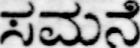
ಸಮನೆ
